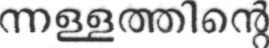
ന്നള്ളത്തിന്റെ
